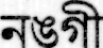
নঙগী
